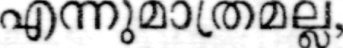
എന്നുമാത്രമല്ല,
